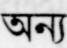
অন্য
